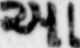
આ
